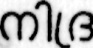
നിദ്ര
